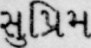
સુપ્રિમ
